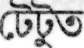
টেটুত
